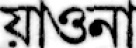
য়াওনা
